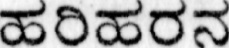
ಹರಿಹರನ
